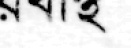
দরখাস্থ
